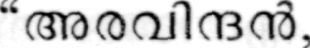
"അരവിന്ദന്‍,
